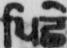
ਪਿਛੇ
